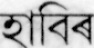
হাবিৰ
